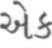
એક
